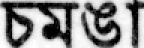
চমঙা
